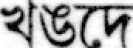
খঙদে
